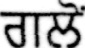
ਗਲੋਂ
